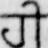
ਹੀ
